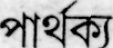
পার্থক্য
